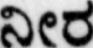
ನೀರ
